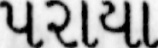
પરાયા
